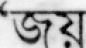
'জয়
